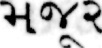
મજૂર
